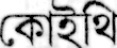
কোইথি
